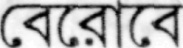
বেরোবে
